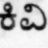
ಕಿವಿ
